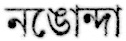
নঙোন্দা
